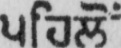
ਪਹਿਲੋਂ
